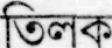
তিলক
